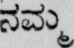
ನಮ್ಮ
